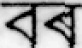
বৰ
